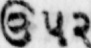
ઉપર
